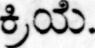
ಕ್ರಿಯೆ.
